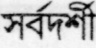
সর্বদর্শী
